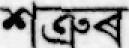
শত্রুৰ
